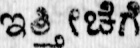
ಇತ್ತೀಚೆಗೆ
